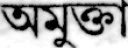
অমুক্তা
